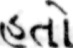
હતો
